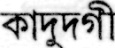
কাদুদগী
